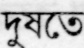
দুষতে
